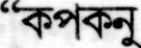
“কপকনু
